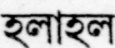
হলাহল
